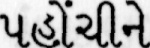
પહોંચીને
